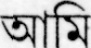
আমি
